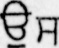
ਉਸ
